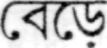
বেড়ে
